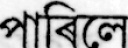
পাৰিলে
